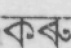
কৰু
